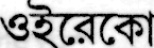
ওইরেকো
